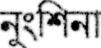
নুংশিনা
